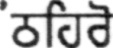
'ਠਹਿਰੋ
